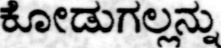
ಕೋಡುಗಲ್ಲನ್ನು
